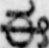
ಈ
